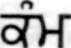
ਕੰਮ
